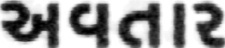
અવતાર
